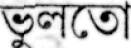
ভুলতো
